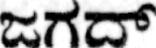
ಜಗದ್
